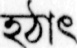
হঠাত্
